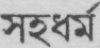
সহধৰ্ম
